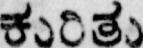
ಕುರಿತು
